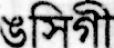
ঙসিগী
